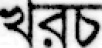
খরচ
